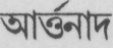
আৰ্ত্তনাদ
